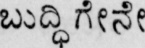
ಬುದ್ಧಿಗೇನೇ
